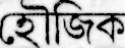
হৌজিক
